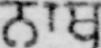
ਨਾਥ
